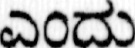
ಎಂದು
